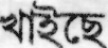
খাইছে
